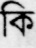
কি
